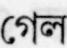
গেল
